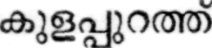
കുളപ്പുറത്ത്
